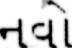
નવો
